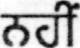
ਨਹੀਂ
